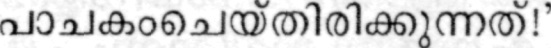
പാചകംചെയ്തിരിക്കുന്നത്!’
